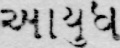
આયુધ
